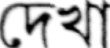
দেখা
